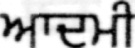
ਆਦਮੀ
